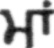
ਮਾਂ
